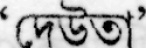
'দেউতা'
